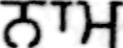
ਨਾਮ
